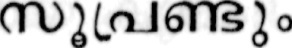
സൂപ്രണ്ടും
